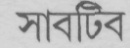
সাবটিব
